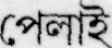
পেলাই
